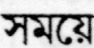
সময়ে
